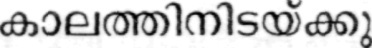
കാലത്തിനിടയ്ക്കു
